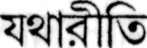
যথারীতি
